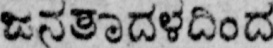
ಜನತಾದಳದಿಂದ
